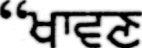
''ਖਾਵਣ
